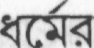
ধর্মের
